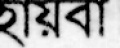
হায়বা
